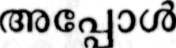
അപ്പോള്‍
